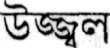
উজ্জ্বল
